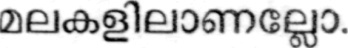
മലകളിലാണല്ലോ.
